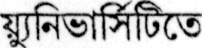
য়্যুনিভার্সিটিতে
